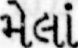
મેલાં
